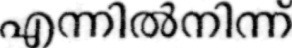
എന്നില്‍നിന്ന്
